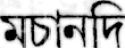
মচানদি
